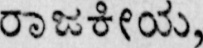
ರಾಜಕೀಯ,
